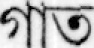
গাত
